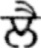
ਲੈ
